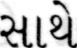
સાથે
